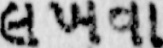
લખવા
